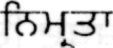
ਨਿਮ੍ਰਤਾ
